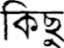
কিছু
